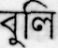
বুলি
